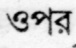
ওপর
